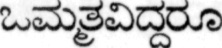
ಒಮ್ಮತವಿದ್ದರೂ
